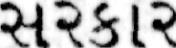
સરકાર
